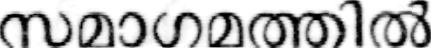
സമാഗമത്തില്‍
